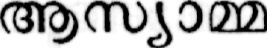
ആസ്യാമ്മ
